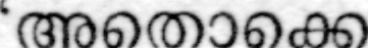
‘അതൊക്കെ
